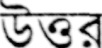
উত্তর
